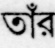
তাঁর
